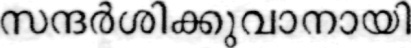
സന്ദര്‍ശിക്കുവാനായി
